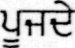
ਪੂਜਦੇ
